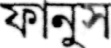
ফানুস
